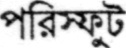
পরিস্ফুট
